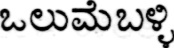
ಒಲುಮೆಬಳ್ಳಿ
